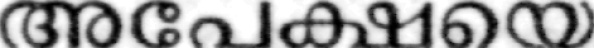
അപേക്ഷയെ
